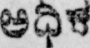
ಅಧಿಕ
